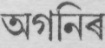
অগনিৰ
